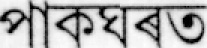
পাকঘৰত
